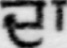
ਦਾ
